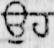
ਉਹ
